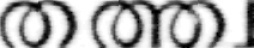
തത്ത്വ
